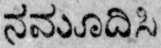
ನಮೂದಿಸಿ
